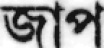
জাপ
